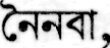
নৈনবা,
